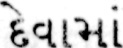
દેવામાં
